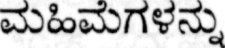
ಮಹಿಮೆಗಳನ್ನು
